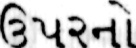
ઉપરનો
